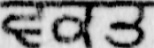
ਵਕਤ
